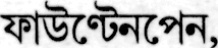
ফাউণ্টেনপেন,
